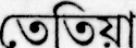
তেতিয়া
